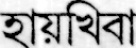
হায়খিবা
